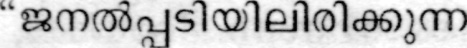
"ജനല്‍പ്പടിയിലിരിക്കുന്ന
